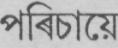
পৰিচায়ে
